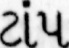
ટાંપ
